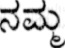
ನಮ್ಮ
